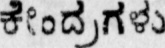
ಕೇಂದ್ರಗಳು
